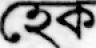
হেক
